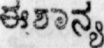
ಈಶಾನ್ಯ
